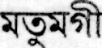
মতুমগী
